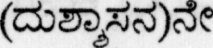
(ದುಶ್ಯಾಸನ)ನೇ
